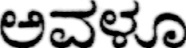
ಅವಳೂ
